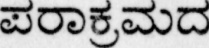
ಪರಾಕ್ರಮದ
